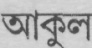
আকুল
